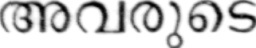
അവരുടെ
